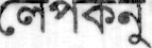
লেপকনু
